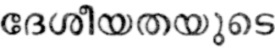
ദേശീയതയുടെ
